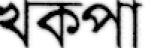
খকপা
